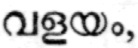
വളയം,
